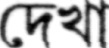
দেখা
